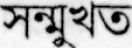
সন্মুখত
